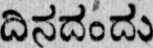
ದಿನದಂದು
